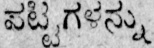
ಪಟ್ಟಿಗಳನ್ನು
